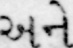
અને
